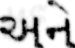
અને
